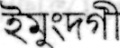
ইমুংদগী
